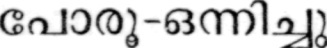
പോരൂ-ഒന്നിച്ചു
